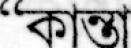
“কান্তা
